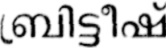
ബ്രിട്ടീഷ്
